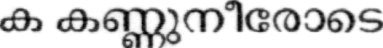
കകണ്ണുനീരോടെ
